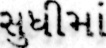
સુધીમાં
